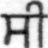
ਸੀ
